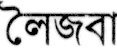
লৈজবা
